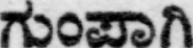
ಗು೦ಪಾಗಿ
